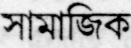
সামাজিক
